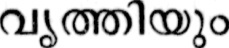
വൃത്തിയും
